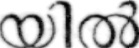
യില്‍
